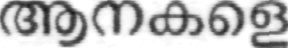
ആനകളെ
